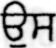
ਉਸ
